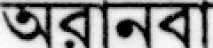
অরানবা
